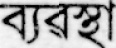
ব্যৱস্হা
